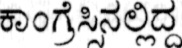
ಕಾಂಗ್ರೆಸ್ಸಿನಲ್ಲಿದ್ದ
